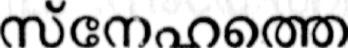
സ്നേഹത്തെ
